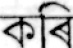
কৰি
